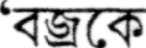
‘বজ্রকে
